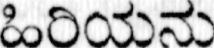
ಹಿರಿಯನು
